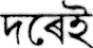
দৰেই
